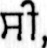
ਸੀ,
